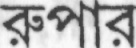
রুপার
